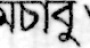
মচাবু
